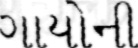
ગાયોની
